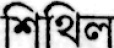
শিথিল
